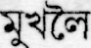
মুখলৈ
